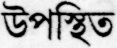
উপস্থিত
